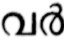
വര്‍
